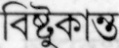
বিষ্টুকান্ত
